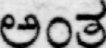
ಅಂತ
